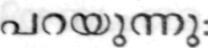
പറയുന്നു:
